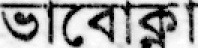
ভাবোক্না
